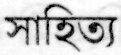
সাহিত্য
